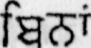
ਬਿਨਾਂ
